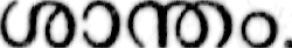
ശാന്തം.
